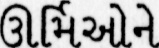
ઊર્મિઓને
